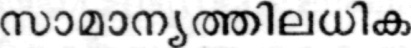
സാമാന്യത്തിലധിക
